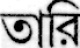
তারি
